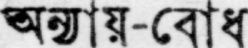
অন্যায়-বোধ
